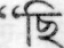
"ছি
